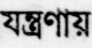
যন্ত্রণায়
